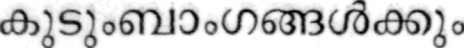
കുടുംബാംഗങ്ങള്‍ക്കും
